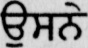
ਉਸਨੇ
